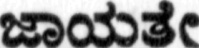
ಜಾಯತೇ
